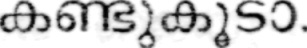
കണ്ടുകൂടാ.
